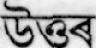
উত্তৰ
